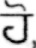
ਹੋ,
